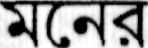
মনের
